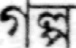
গল্প
